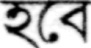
হবে
